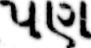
પણ
